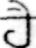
ਹੈ
